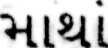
માથાં
